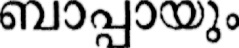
ബാപ്പായും
